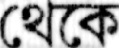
থেকে
